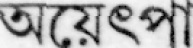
অয়েৎপা
